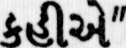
કહીએ"
